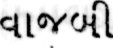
વાજબી
